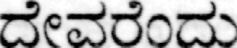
ದೇವರೆಂದು
